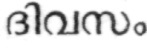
ദിവസം
